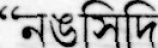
“নঙসিদি
